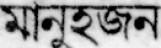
মানুহজন
